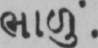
ભાળું.
